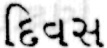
દિવસ
